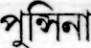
পুন্সিনা
